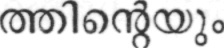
ത്തിന്റെയും
